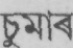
চুমাৰ
